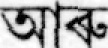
আৰু
